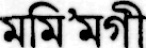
মমি’মগী
